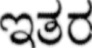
ಇತರ
